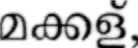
മക്കള്,
